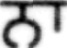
ਨਾ
